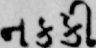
નકકી
